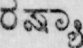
ರಷ್ಯಾ
